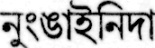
নুংঙাইনিদা
